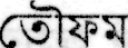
তৌফম
